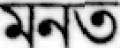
মনত
